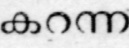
കറന്ന
